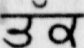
ਤੱਕ
